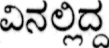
ವಿನಲ್ಲಿದ್ದ
